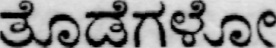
ತೊಡೆಗಳೋ
